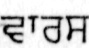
ਵਾਰਸ
